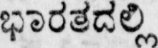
ಭಾರತದಲ್ಲಿ
